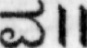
ವ||
